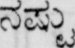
ನಷ್ಟು
